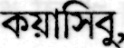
কয়াসিবু,
